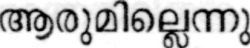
ആരുമില്ലെന്നു
